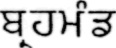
ਬ੍ਰਹਮੰਡ
